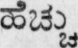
ಹೆಚ್ಚು
